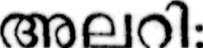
അലറി:
